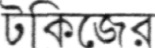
টকিজের
